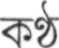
কণ্ঠ
